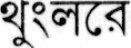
থুংলরে
